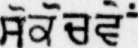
ਸੋਕੋਚਵੇਂ
